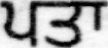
ਪਤਾ
